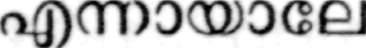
എന്നായാലേ
